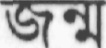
জন্ম
